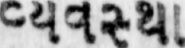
વ્યવસ્થા
